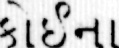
કોઇના
